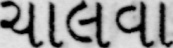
ચાલવા
